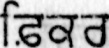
ਫ਼ਿਕਰ
